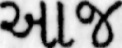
આજ
